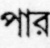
পার
